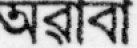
অৱাবা
